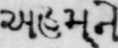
અહમને
